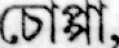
চোপ্পা,
